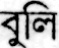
বুলি
